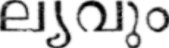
ല്യവും
